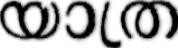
യാത്ര
